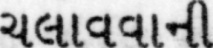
ચલાવવાની
